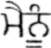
ਮੈਨੂੰ
